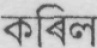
কৰিল
